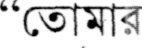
“তোমার
